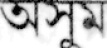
অসুম
